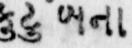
કુટુંબના
